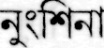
নুংশিনা
